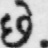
છે.
